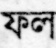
ফল
